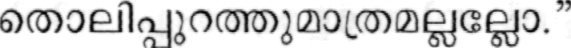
തൊലിപ്പുറത്തുമാത്രമല്ലല്ലോ."
